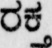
ರಕ್ತ
